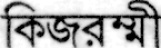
কিজরম্মী
